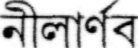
নীলার্ণব
